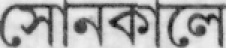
সোনকালে
